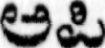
ಅಪಿ
